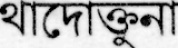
থাদোক্তুনা
